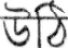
উঠি
